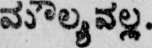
ಮೌಲ್ಯವಲ್ಲ.
